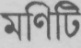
মণিটি
